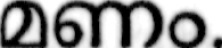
മണം.
